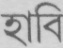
হাবি
